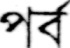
পর্ব
